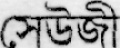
সেউজী
